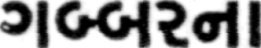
ગબ્બરના
